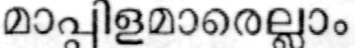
മാപ്പിളമാരെല്ലാം
